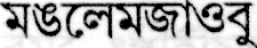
মঙলেমজাওবু
